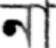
না
